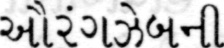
ઔરંગઝેબની
